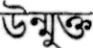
উন্মুক্ত
